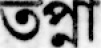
তপ্না
